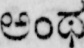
ಅಂಥ
